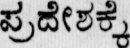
ಪ್ರದೇಶಕ್ಕೆ
